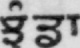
ਝੰਡਾ
